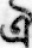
ঐ
